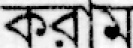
করাম
